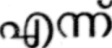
എന്ന്
